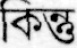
কিন্তু
